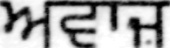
ਅਵਾਜ਼
